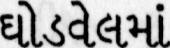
ઘોડવેલમાં
